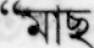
"মাছ
